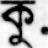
কু.
